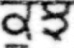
ਕੁਝ
